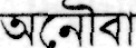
অনৌবা
